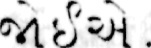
જોઈએ.
